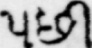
પછી
